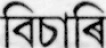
বিচাৰি
